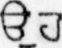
ਉਹ
